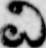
ವಿ
